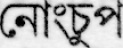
নোংচুপ
